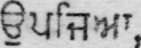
ਉਪਜਿਆ,
